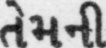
તેમની
